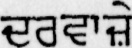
ਦਰਵਾਜ਼ੇ
